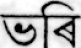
ভৰি
